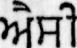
ਐਸੀ
